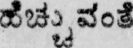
ಹೆಚ್ಚುವಂತೆ
